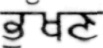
ਭੁੱਖਣ
